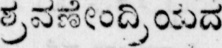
ಶ್ರವಣೇಂದ್ರಿಯದ
